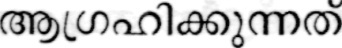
ആഗ്രഹിക്കുന്നത്
